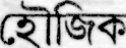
হৌজিক
